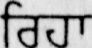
ਰਿਹਾ
